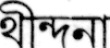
থীন্দনা
